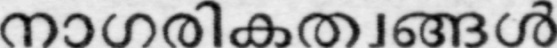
നാഗരികത്വങ്ങള്‍
